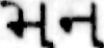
મન
